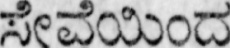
ಸೇವೆಯಿಂದ
